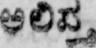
ಅಲಿಪ್ತ
